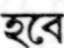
হবে
